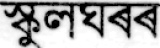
স্কুলঘৰৰ
